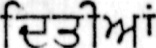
ਦਿਤੀਆਂ
